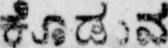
ಕೊಡುವ
